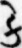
કે
